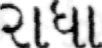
રાધા
